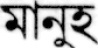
মানুহ
